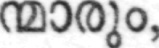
ന്മാരും,
